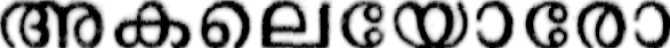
അകലെയോരോ
